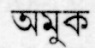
অমুক
